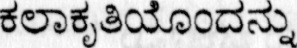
ಕಲಾಕೃತಿಯೊಂದನ್ನು
